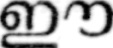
ഈ
